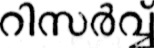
റിസര്‍വ്വ്
